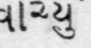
વાંચ્યું
